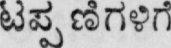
ಟಪ್ಪಣಿಗಳಿಗೆ
